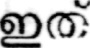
ഇത്
